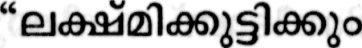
“ലക്ഷ്മിക്കുട്ടിക്കും
